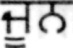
ਜੂਨ
